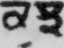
ਕੁਝ
